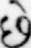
છે
